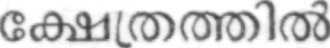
ക്ഷേത്രത്തില്‍
